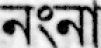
নংনা
